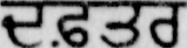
ਦਫ਼ਤਰ
